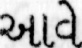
આવે
